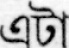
এটা
